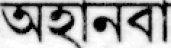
অহানবা
